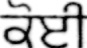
ਕੋਈ
